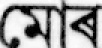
মোৰ
